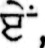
ਏਂ,
